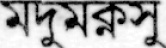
মদুমক্নসু
